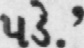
પડે.'
